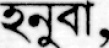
হনুবা,
